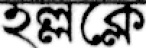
হল্লক্লে
